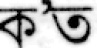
ক'ত
